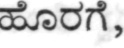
ಹೊರಗೆ,
